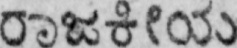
ರಾಜಕೀಯ
